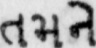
તમને
